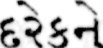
દરેકને
